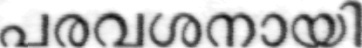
പരവശനായി
